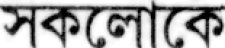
সকলোকে
